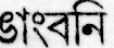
ঙাংবনি
